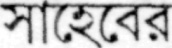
সাহেবের
